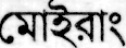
মোইরাং
